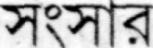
সংসার
